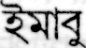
ইমাবু
